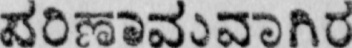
ಪರಿಣಾಮವಾಗಿರ
